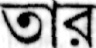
তার
